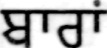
ਬਾਰਾਂ
